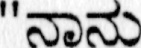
“ನಾನು
